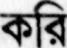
করি
